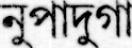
নুপাদুগা
